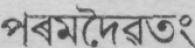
পৰমদৈৱতং
